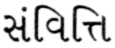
સંવિત્તિ
